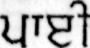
ਪਾਈ
